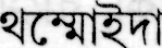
থম্মোইদা
